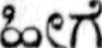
ಹೀಗೆ
